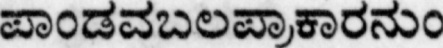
ಪಾಂಡವಬಲಪ್ರಾಕಾರನುಂ
